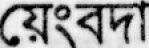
য়েংবদা
